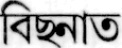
বিছনাত
